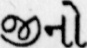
જીનો
